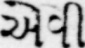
એવી
